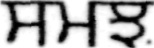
ਸਮਝ
